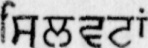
ਸਿਲਵਟਾਂ
